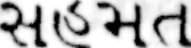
સહમત
